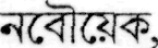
নবৌয়েক,
